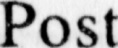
Post
